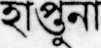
হাপ্তুনা
